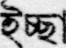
ইচ্ছা
